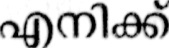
എനിക്ക്
